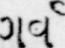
ગર્વ
